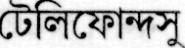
টেলিফোন্দসু
